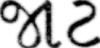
જાટ
